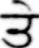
ਤੇ
